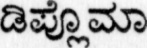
ಡಿಪ್ಲೊಮಾ
